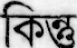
কিন্তু
